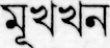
মূখখন
